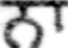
ਨਾ
